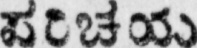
ಪರಿಚಯ
